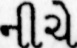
નીચે
